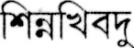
শিন্নখিবদু
